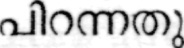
പിറന്നതു
